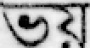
ভয়
